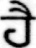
ਹੈ
